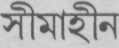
সীমাহীন
